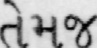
તેમજ
